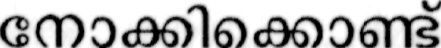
നോക്കിക്കൊണ്ട്
